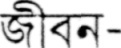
জীবন-
